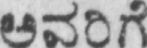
ಅವರಿಗೆ
